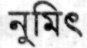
নুমিৎ
